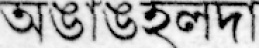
অঙাঙহলদা
